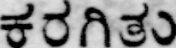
ಕರಗಿತು
